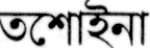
তশোইনা
